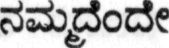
ನಮ್ಮದೆಂದೇ
